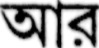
আর
